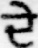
ਦੇ
